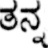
ತನ್ನ
